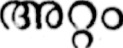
അറ്റം
